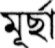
মূর্ছা
